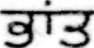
ਭਾਂਤ
